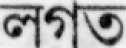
লগত
